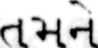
તમને
